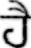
ਹੈ
